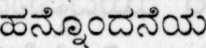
ಹನ್ನೊಂದನೆಯ
